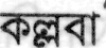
কল্লবা
